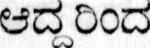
ಆದ್ದರಿಂದ
